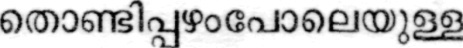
തൊണ്ടിപ്പഴംപോലെയുള്ള
